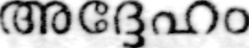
അദ്ദേഹം
